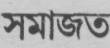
সমাজত
